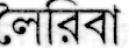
লৈরিবা
